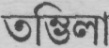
তম্ভিলা
